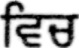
ਵਿਚ
